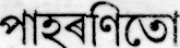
পাহৰণিতো
